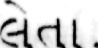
લેતા.
